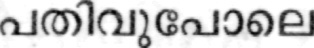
പതിവുപോലെ
